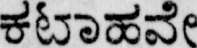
ಕಟಾಹವೇ
